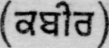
(ਕਬੀਰ)
